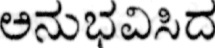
ಅನುಭವಿಸಿದ
